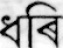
ধৰি
